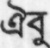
ঐবু
